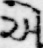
એ
